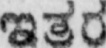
ಇತರ
